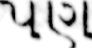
પણ
